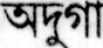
অদুগা
